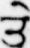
ਤੇ
